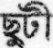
ছুটী
